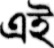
এই
